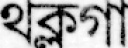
থক্লগা
